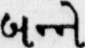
બન્ને
